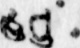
હતું.
